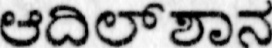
ಆದಿಲ್‌ಶಾನ
